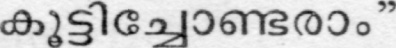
കൂട്ടിച്ചോണ്ടരാം"
